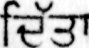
ਦਿੱਤਾ
